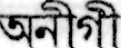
অনীগী
